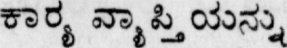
ಕಾರ್‍ಯವ್ಯಾಪ್ತಿಯನ್ನು
